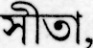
সীতা,
